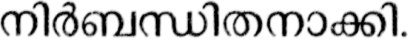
നിര്‍ബന്ധിതനാക്കി.
